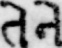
તેને
